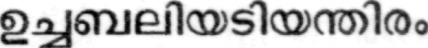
ഉച്ചബലിയടിയന്തിരം
